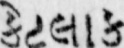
કેટલાક
